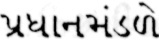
પ્રધાનમંડળે
